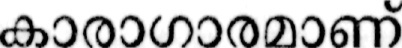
കാരാഗാരമാണ്
